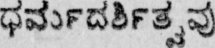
ಧರ್ಮದರ್ಶಿತ್ವವು
